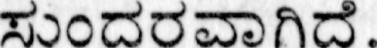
ಸುಂದರವಾಗಿದೆ.
